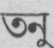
তনু
